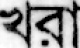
খরা
